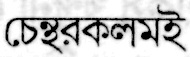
চেন্থরকলমই
